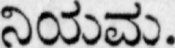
ನಿಯಮ.
